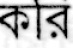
করি
